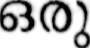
ഒരു
